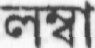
লম্বা
